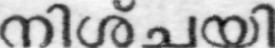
നിശ്ചയി
